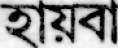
হায়বা
